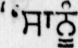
''ਸਾਨੂੰ
